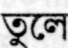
তুলে
